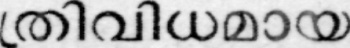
ത്രിവിധമായ
